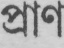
প্ৰাণ
